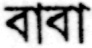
বাবা
